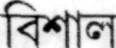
বিশাল
